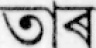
তাৰ
